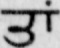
ਤਾਂ
